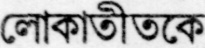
লোকাতীতকে
